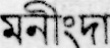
মনীংদা
